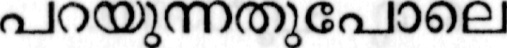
പറയുന്നതുപോലെ
